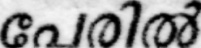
പേരില്‍
